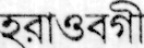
হরাওবগী
